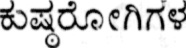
ಕುಷ್ಠರೋಗಿಗಳ
